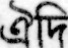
ঐদি
